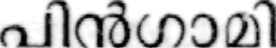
പിന്‍ഗാമി
